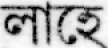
লাহে
